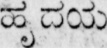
ಹೃದಯ
